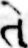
તે
